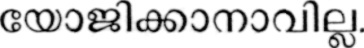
യോജിക്കാനാവില്ല.
